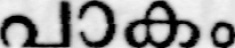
പാകം
